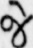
જે
